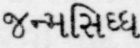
જન્મસિધ્ધ
